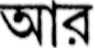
আর
